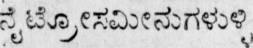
ನೈಟ್ರೋಸಮೀನುಗಳುಳ್ಳಿ
